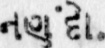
નણંદો.
